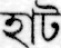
হাট
